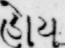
હોય
